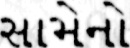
સામેનો
